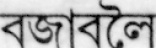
বজাবলৈ
